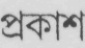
প্ৰকাশ
